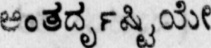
ಅಂತರ್ದೃಷ್ಟಿಯೇ
